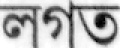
লগত
